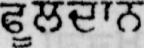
ਫੂਲਦਾਨ
